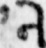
ને
